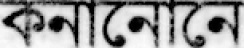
কনানোনে
